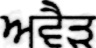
ਅਵੈੜ
